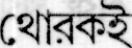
থোরকই
